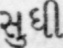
સુધી
